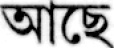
আছে
